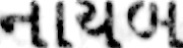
નાયબ
